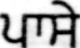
ਪਾਸੇ
